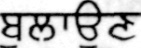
ਬੁਲਾਉਣ
